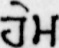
ਹੇਮ
